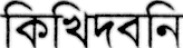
কিখিদবনি
